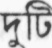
দুটি
